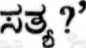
ಸತ್ಯ?’
